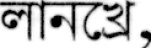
লানখ্রে,
